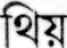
থিয়
